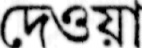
দেওয়া
